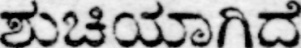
ಶುಚಿಯಾಗಿದೆ
